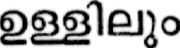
ഉള്ളിലും
